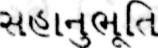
સહાનુભૂતિ
